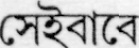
সেইবাবে
